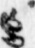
હું
